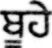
ਬੂਹੇ
